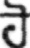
ਹੋ
